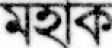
মহাক
